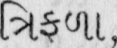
ત્રિફળા,
